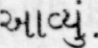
આવ્યું.
